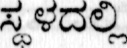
ಸ್ಥಳದಲ್ಲಿ
